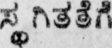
ಸ್ಥಗಿತತೆಗೆ
